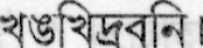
খঙখিদ্রবনি।
